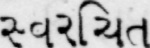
સ્વરચિત
